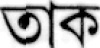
তাক
